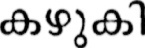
കഴുകി
